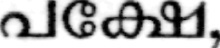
പക്ഷേ,
